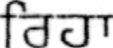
ਰਿਹਾ
